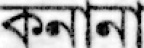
কনানা
